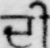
ਦੀ
